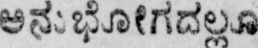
ಅನುಭೋಗದಲ್ಲೂ
